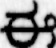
ಈ
